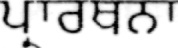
ਪ੍ਰਾਰਥਨਾ
